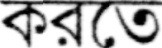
করতে
